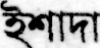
ইশাদা
